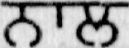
ਨਾਲ
